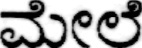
ಮೇಲೆ
